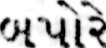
બપોરે
